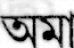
অমা
